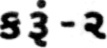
કરૂં-૨
